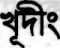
খূদীং
